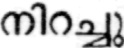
നിറച്ചു
